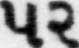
પર
